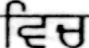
ਵਿਚ
